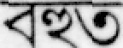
বহুত
